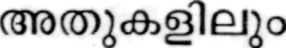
അതുകളിലും
